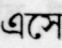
এসে
